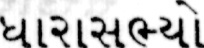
ધારાસભ્યો
